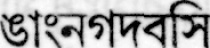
ঙাংনগদবসি
